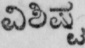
ವಿಶಿಷ್ಟ
